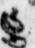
હું
